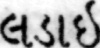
લડાઈ
